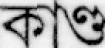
কাণ্ড
